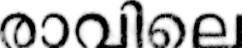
രാവിലെ
